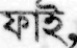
ফাই,
